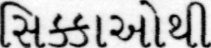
સિક્કાઓથી
